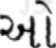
ઓ
